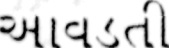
આવડતી
